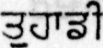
ਤੁਹਾਡੀ
